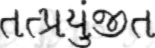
તત્પ્રયુંજીત
